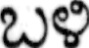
ಬಳಿ
